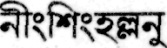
নীংশিংহল্লনু
